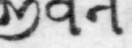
જીવન
